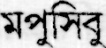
মপুসিবু
